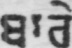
ਬਾਰੇ
